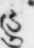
હું
